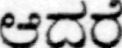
ಆದರೆ
